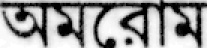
অমরোম
